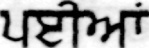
ਪਈਆਂ
